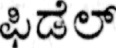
ಫಿಡೆಲ್
